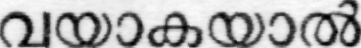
വയാകയാല്‍
